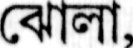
ঝোলা,
